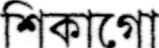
শিকাগো
